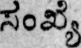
ಸಂಖ್ಯೆ
